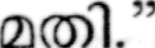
മതി."
